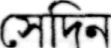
সেদিন
